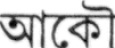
আকৌ
